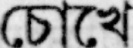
চোখে
